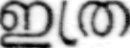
ഇത്ര
